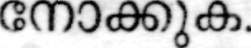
നോക്കുക.
